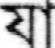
যা
